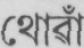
থোৱাঁ
